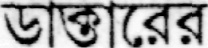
ডাক্তারের
